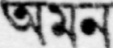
অমন
